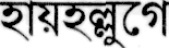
হায়হল্লুগে
